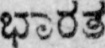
ಭಾರತ
